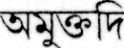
অমুক্তদি
